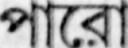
পারো
